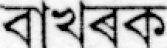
বাখৰক
